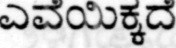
ಎವೆಯಿಕ್ಕದೆ
